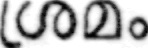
ശ്രമം
